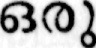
ഒരു
